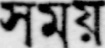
সময়
